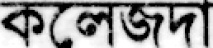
কলেজদা
